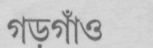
গড়গাঁও
